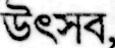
উৎসব,
